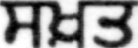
ਸਖ਼ਤ
